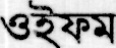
ওইফম
